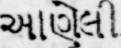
આણેલી
